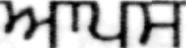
ਆਪਸ
